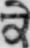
ਕੇ
